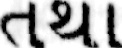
તથા
